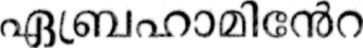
ഏബ്രഹാമിന്റേ
